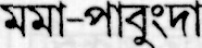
মমা-পাবুংদা
